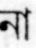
না
